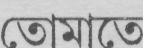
তোমাতে
